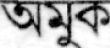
অমুক
